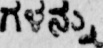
ಗಳನ್ನು
